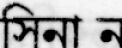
মরিদনি
